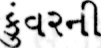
કુંવરની
